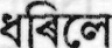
ধৰিলে
